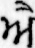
ਐ
